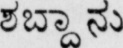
ಶಬ್ದಾನು
